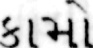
કામો
